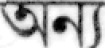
অন্য
